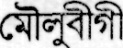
মৌলুবীগী
